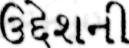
ઉદ્દેશની
